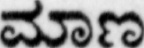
ಮಾಣ
